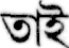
তাই
